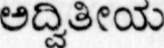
ಅದ್ವಿತೀಯ
